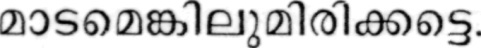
മാടമെങ്കിലുമിരിക്കട്ടെ.
